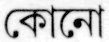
কোনো
